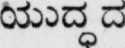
ಯುದ್ಧದ
